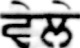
ਵੇਲੇ
